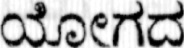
ಯೋಗದ
